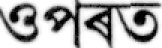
ওপৰত
